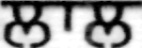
ਲਾਲ
